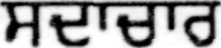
ਸਦਾਚਾਰ
